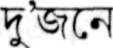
দু’জনে
